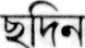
ছদিন
